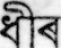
ধীৰ
